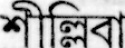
শীল্লিবা
